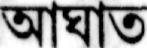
আঘাত
